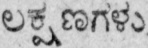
ಲಕ್ಷಣಗಳು
